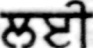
ਲਈ
